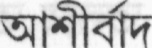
আশীর্বাদ
